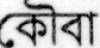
কৌবা
